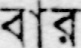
বার
